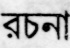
রচনা
